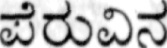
ಪೆರುವಿನ
